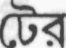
টের
